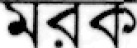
মরক
